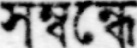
সম্বন্ধে
